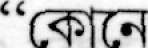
"কোনে
